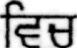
ਵਿਚ
